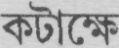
কটাক্ষে
